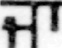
ਜਾ
